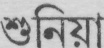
শুনিয়া
